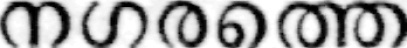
നഗരത്തെ
